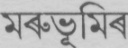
মৰুভূমিৰ
